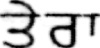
ਤੇਰਾ
